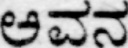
ಅವನ
